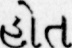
હોત
